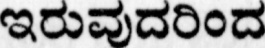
ಇರುವುದರಿಂದ
